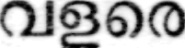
വളരെ
